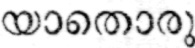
യാതൊരു
